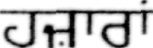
ਹਜ਼ਾਰਾਂ
